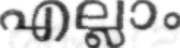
എല്ലാം
